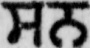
ਸਨ
